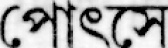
পোৎসে
